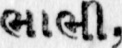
ભાભી,
